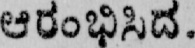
ಆರಂಭಿಸಿದ.
